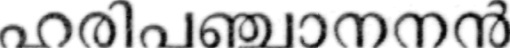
ഹരിപഞ്ചാനനന്‍
